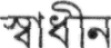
স্বাধীন
